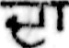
ਦਾ
